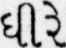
ધીરે
